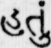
હતું
